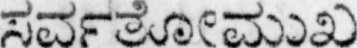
ಸರ್ವತೋಮುಖ
